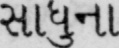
સાધુના
